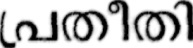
പ്രതീതി
